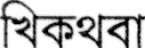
খিকথবা
